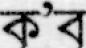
ক'ব
